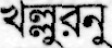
খল্লুরনু
